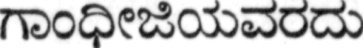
ಗಾಂಧೀಜಿಯವರದು
